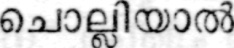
ചൊല്ലിയാല്‍
